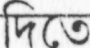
দিতে
